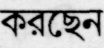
করছেন
